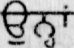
ਉਨ੍ਹਾਂ
